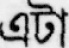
এটা
